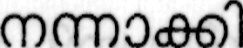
നന്നാക്കി
